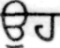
ਉਹ
